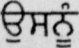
ਉਸਨੂੰ
